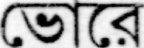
ভোরে
